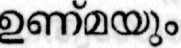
ഉണ്മയും
